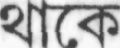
থাকে
